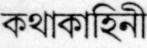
কথাকাহিনী
